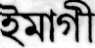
ইমাগী
